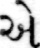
એ
